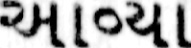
આવ્યા
